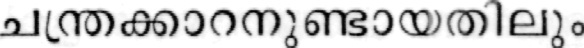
ചന്ത്രക്കാറനുണ്ടായതിലും
